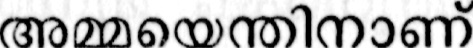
അമ്മയെന്തിനാണ്
